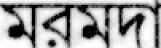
মরমদা
